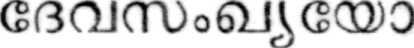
ദേവസംഖ്യയോ
